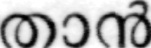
താന്‍
